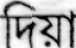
দিয়া
